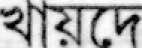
খায়দে
